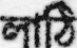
লাঠি
